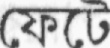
ফেটে
